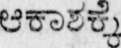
ಆಕಾಶಕ್ಕೆ
